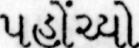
પહોંચ્યો
